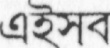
এইসব
